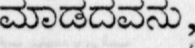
ಮಾಡದವನು,
